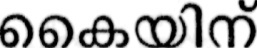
കൈയിന്
